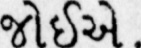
જોઈએ.
